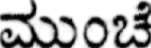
ಮುಂಚೆ
